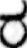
ರ
